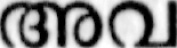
അവ
